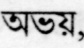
অভয়,
